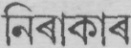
নিৰাকাৰ
